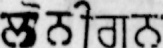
ਲੋਨੀਗਨ
